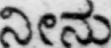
ನೀನು
